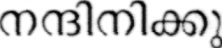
നന്ദിനിക്കു
